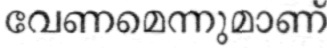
വേണമെന്നുമാണ്
